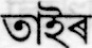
তাইৰ
